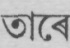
তাৰে
